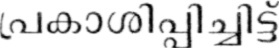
പ്രകാശിപ്പിച്ചിട്ട്
